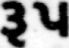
રૂપ
